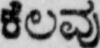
ಕೆಲವು
